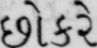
છોકરે
